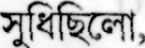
সুধিছিলো,
